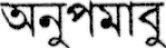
অনুপমাবু
